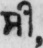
ਸੀ,
